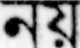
নয়
